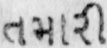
તમારી
